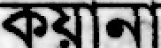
কয়ানা
